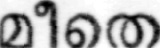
മീതെ
